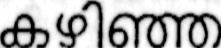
കഴിഞ്ഞ
